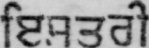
ਇਸਤਰੀ
